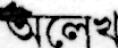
অলেখ
